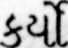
કર્યો
